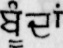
ਬੂੰਦਾਂ
